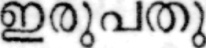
ഇരുപതു
